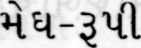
મેઘ-રૂપી
